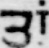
ਤਾਂ
